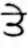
ਤੇ
